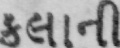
કલાની
